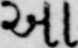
આ
